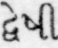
દ્વેષી
